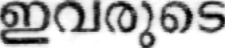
ഇവരുടെ
